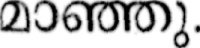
മാഞ്ഞു.
